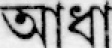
আধা
